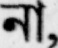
না,
